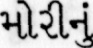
મોરીનું
